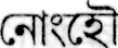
নোংহৌ
